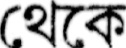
থেকে
